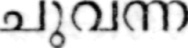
ചുവന്ന
